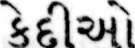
કેદીઓ
